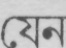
যেন
